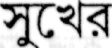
সুখের
